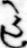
હે
